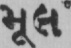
મૂલં
